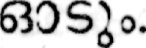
ഓടും.
